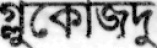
গ্লুকোজদু
